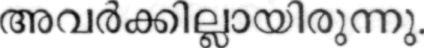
അവര്‍ക്കില്ലായിരുന്നു.
